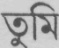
তুমি
